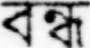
বন্ধ
